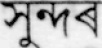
সুন্দৰ
